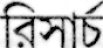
রিসার্চ
